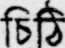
চিঠি
